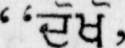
''ਦੇਖੋ,
